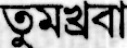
তুমখ্রবা
